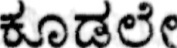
ಕೂಡಲೇ
